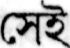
সেই
